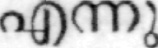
എന്നു
